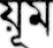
য়ূম
